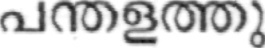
പന്തളത്തു
